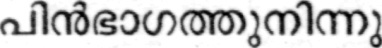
പിന്‍ഭാഗത്തുനിന്നു
